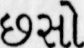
છસો
